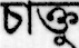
চাক্তু
